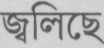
জ্বলিছে
